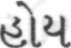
હોય
